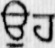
ਉਹ
